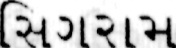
સિગરામ
